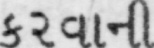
કરવાની
